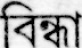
বিন্ধা
